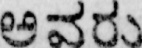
ಅವರು
